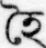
হৈ
